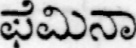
ಫೆಮಿನಾ
